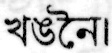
খঙনৈ।
